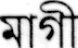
মাগী
